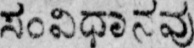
ಸಂವಿಧಾನವು
